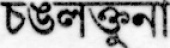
চঙলক্তুনা
